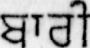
ਬਾਰੀ
